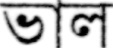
ভাল
